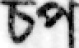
চপ
